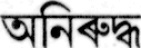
অনিৰুদ্ধ
